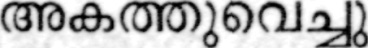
അകത്തുവെച്ചു
